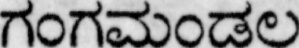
ಗಂಗಮಂಡಲ
